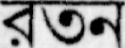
রতন
